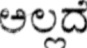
ಅಲ್ಲದೆ
